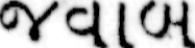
જવાબ
